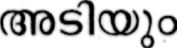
അടിയും
